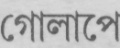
গোলাপে
